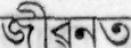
জীৱনত
